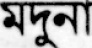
মদুনা
